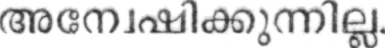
അന്വേഷിക്കുന്നില്ല.
